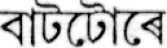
বাটটোৰে
